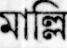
মাল্লি
